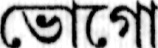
ভোগো
